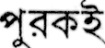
পুরকই
